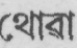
থোৱা
